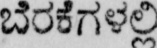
ಬೆರಕೆಗಳಲ್ಲಿ
